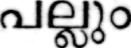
പല്ലും
